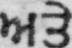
ਅਤੇ
